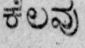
ಕೆಲವು
